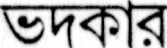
ভদকার
